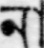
না
